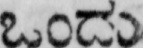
ಒಂದು
